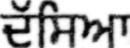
ਦੱਸਿਆ
